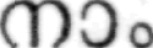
നാം
